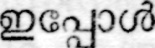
ഇപ്പോള്‍
